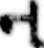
ન
